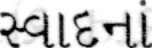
સ્વાદનાં
